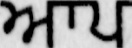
ਆਪ
